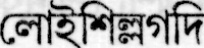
লোইশিল্লগদি
